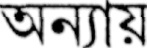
অন্যায়
